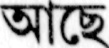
আছে
